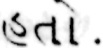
હતો.
